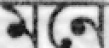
মনে
